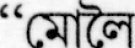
"মোলৈ
